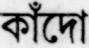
কাঁদো
